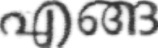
എങ്ങ
